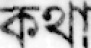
কথা
